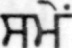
ਸਮੇਂ
